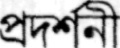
প্রদর্শনী
